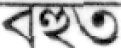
বহুত
